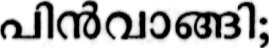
പിന്‍വാങ്ങി;
